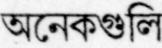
অনেকগুলি
